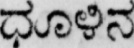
ಧೂಳಿನ
